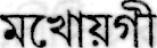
মখোয়গী
